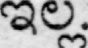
ಇಲ್ಲ.
